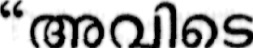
“അവിടെ
